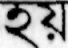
হয়
